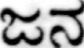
ಜನ
